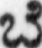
ಬೆ
